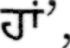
ਹਾਂ',
